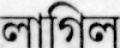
লাগিল
